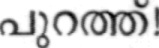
പുറത്ത്!
